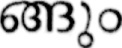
ങ്ങും
